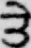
ਤੇ
